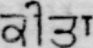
ਕੀਤਾ
